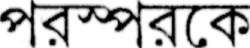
পরস্পরকে
